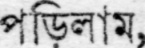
পড়িলাম,
